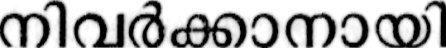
നിവര്‍ക്കാനായി
